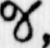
જ,
